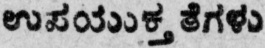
ಉಪಯುಕ್ತತೆಗಳು
